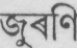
জুৰণি
